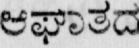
ಆಘಾತದ
